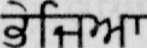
ਭੇਜਿਆ
